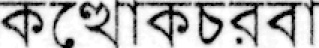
কত্থোকচরবা
